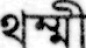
থম্মী
